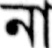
না
